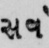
સર્વ
